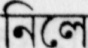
নিলে
